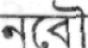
নবৌ
